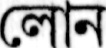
লোন
